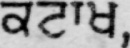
ਕਟਾਖ,
